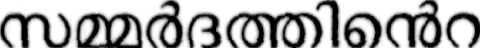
സമ്മര്‍ദത്തിന്റെ
